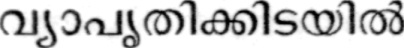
വ്യാപൃതിക്കിടയില്‍
